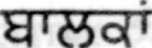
ਬਾਲਾਕਾਂ
